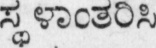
ಸ್ಥಳಾಂತರಿಸಿ
